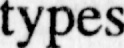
types
